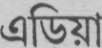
এড়িয়া
